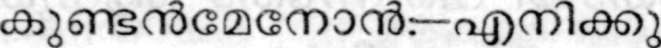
കുണ്ടന്‍മേനോന്‍:-എനിക്കു
